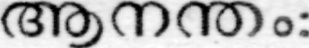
ആനന്തം:
